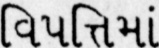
વિપત્તિમાં
